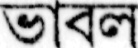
ভাবল
